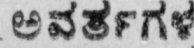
ಅವರ್ತಗಳ
